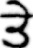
ਤੇ
